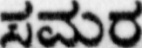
ಸಮರ
